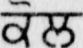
ਕੋਲ
